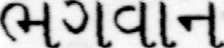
ભગવાન
